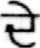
ਦੇ
